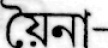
য়ৈনা-
